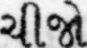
ચીજો
